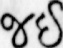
જઈ
